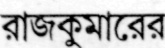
রাজকুমারের
